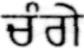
ਚੰਗੇ
